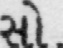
સો.
